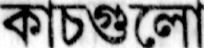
কাচগুলো
